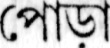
পোড়া
